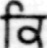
ਕਿ
